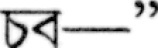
চব-"
